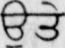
ਉਤੇ
